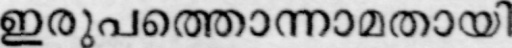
ഇരുപത്തൊന്നാമതായി
